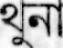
থুনা
